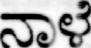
ನಾಳೆ
